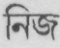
নিজ
